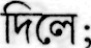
দিলে;
